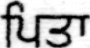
ਪਿਤਾ
